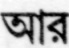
আর
